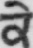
ਕੇ
